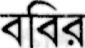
ববির
